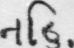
નહિ.
